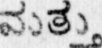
ಮತ್ತು
